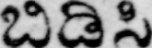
ಬಿಡಿಸಿ
